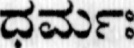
ಧರ್ಮಃ
